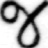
જ
